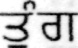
ਤੁੰਗ
